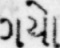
ગયો
